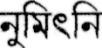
নুমিৎনি
